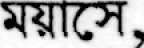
ময়াসে,
